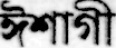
ঈশাগী
